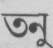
তনু
